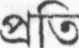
প্রতি
